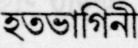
হতভাগিনী
